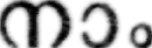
നാം
